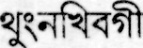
থুংনখিবগী
